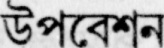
উপবেশন
